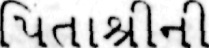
પિતાશ્રીની
